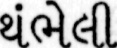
થંભેલી
